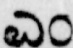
ಎಂ
